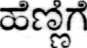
ಹೆಣ್ಣಿಗೆ
